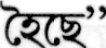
হৈছে"
